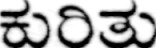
ಕುರಿತು
